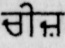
ਚੀਜ਼
